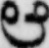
ಆ
